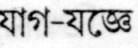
যাগ-যজ্ঞে
